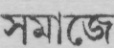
সমাজে
